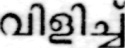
വിളിച്ച്
